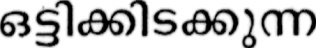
ഒട്ടിക്കിടക്കുന്ന
